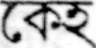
কেহ
